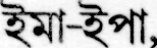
ইমা-ইপা,
